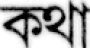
কথা
